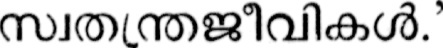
സ്വതന്ത്രജീവികള്‍.’
